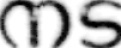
നട
